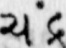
ચંદ્ર
